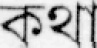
কথা
